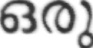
ഒരു
